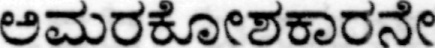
ಅಮರಕೋಶಕಾರನೇ
